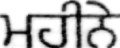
ਮਹੀਨੇ
